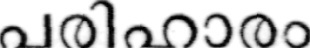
പരിഹാരം
